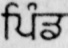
ਪਿੰਡ
